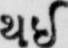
થઈ
